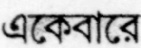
একেবারে
